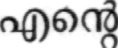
എന്റെ
